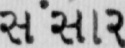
સંસાર
